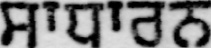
ਸਾਧਾਰਨ
